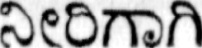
ನೀರಿಗಾಗಿ
